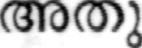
അതു
